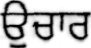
ਉਚਾਰ
